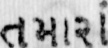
તમારાં
